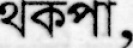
থকপা,
